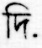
দি.
